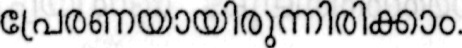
പ്രേരണയായിരുന്നിരിക്കാം.
